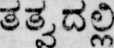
ತತ್ವದಲ್ಲಿ
